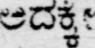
ಅದಕ್ಕೇ
